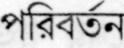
পরিবর্তন
